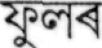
ফুলৰ
